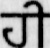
ਹੀ
